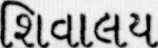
શિવાલય
